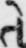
તે
